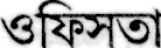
ওফিসতা
